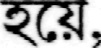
হয়ে,
